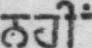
ਨਹੀਂ
